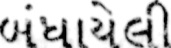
બંધાયેલી
